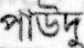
পাউদু
